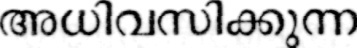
അധിവസിക്കുന്ന
